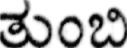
ತುಂಬಿ
